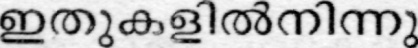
ഇതുകളില്‍നിന്നു
